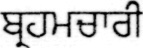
ਬ੍ਰਹਮਚਾਰੀ
